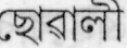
ছোৱালী
